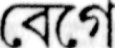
বেগে
